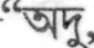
“অদু,
